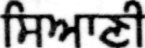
ਸਿਆਣੀ
